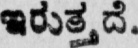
ಇರುತ್ತದೆ.
